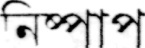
নিষ্পাপ
